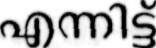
എന്നിട്ട്
